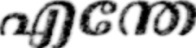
എന്തേ
